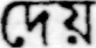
দেয়
